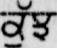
ਕੁੱਝ
